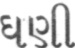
ઘણી
